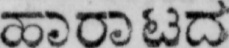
ಹಾರಾಟದ
